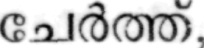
ചേര്‍ത്ത്,
